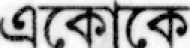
একোকে
